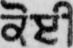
ਕੋਈ
